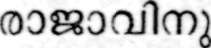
രാജാവിനു
